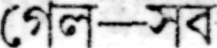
গেল—সব
